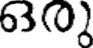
ഒരു
